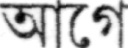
আগে
